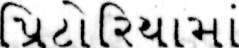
પ્રિટોરિયામાં
